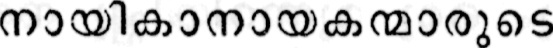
നായികാനായകന്മാരുടെ
